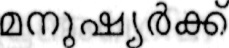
മനുഷ്യര്‍ക്ക്
